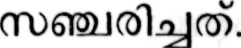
സഞ്ചരിച്ചത്.
